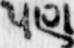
પણ
